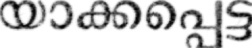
യാക്കപ്പെട്ട
